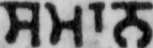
ਸਮਾਨ
